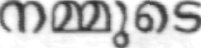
നമ്മുടെ
